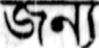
জন্য
